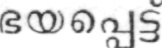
ഭയപ്പെട്ട്
